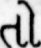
તો
